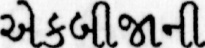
એકબીજાની
